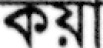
কয়া
